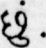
છું.
